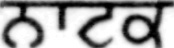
ਨਾਟਕ
